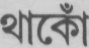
থাকোঁ
